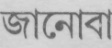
জানোবা
